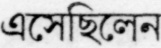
এসেছিলেন
